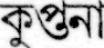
কুপ্তনা
